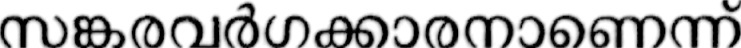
സങ്കരവര്‍ഗക്കാരനാണെന്ന്
